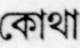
কোথা
